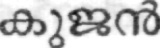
കുജന്‍
